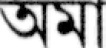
অমা
